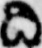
ದಿ
